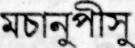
মচানুপীসু
